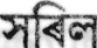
সৰিল
